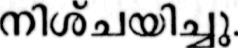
നിശ്ചയിച്ചു.
